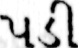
પડી
